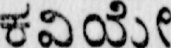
ಕವಿಯೇ
